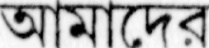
আমাদের
